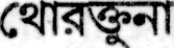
থোরক্তুনা
